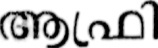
ആഫ്രി
